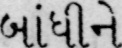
બાંધીને
